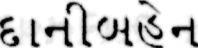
દાનીબહેન
